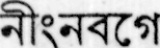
নীংনবগে
